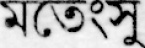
মতেংসু
